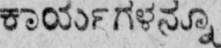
ಕಾರ್ಯಗಳನ್ನೂ
